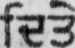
ਦਿਤੇ
